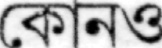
কোনও
